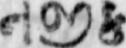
નજીક
